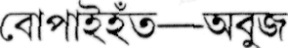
বোপাইহঁত-অবুজ
